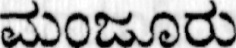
ಮಂಜೂರು
